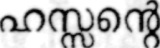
ഹസ്സന്റെ
